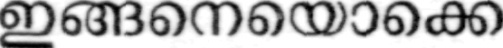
ഇങ്ങനെയൊക്കെ
